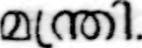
മന്ത്രി.
